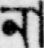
না
